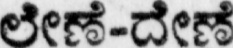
ಲೇಣೆ-ದೇಣೆ
